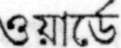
ওয়ার্ডে
